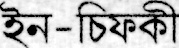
ইন-চিফকী
